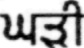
ਘੜੀ
